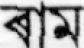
ৰাম
